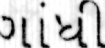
ગાંધી
